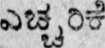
ಎಚ್ಚರಿಕೆ
